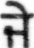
ਜੇ
